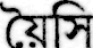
য়ৈসি
